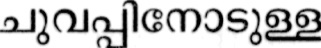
ചുവപ്പിനോടുള്ള
